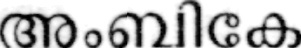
അംബികേ
